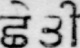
ਛੇਤੀ
